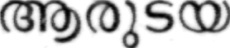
ആരുടയ
